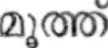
മൂത്ത്
